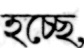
হচ্ছে,
